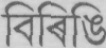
বিৰিঙি
